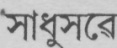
সাধুসৱে
